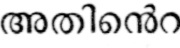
അതിന്റെ
